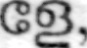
ളേ,
